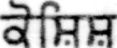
ਕੋਸ਼ਿਸ਼
